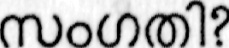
സംഗതി?
